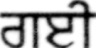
ਗਈ
